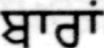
ਬਾਰਾਂ
